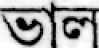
ভাল
